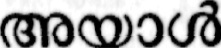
അയാള്‍
